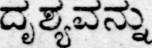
ದೃಶ್ಯವನ್ನು
